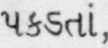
પકડતાં,
